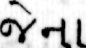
જેના
